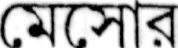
মেসোর
